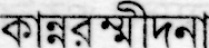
কান্নরম্মীদনা
